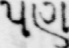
પણ
